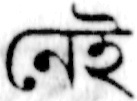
নেই
